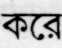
করে
